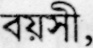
বয়সী,
